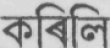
কৰিলি
